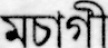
মচাগী
